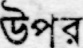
উপর
